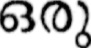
ഒരു
